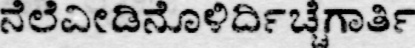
ನೆಲೆವೀಡಿನೊಳಿರ್ದಿಚ್ಚೆಗಾರ್ತಿ
